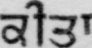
ਕੀਤਾ
